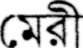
মেরী
